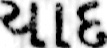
યાદ
